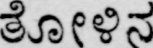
ತೋಳಿನ
